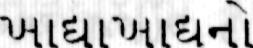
ખાધાખાધનો
